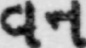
વન
